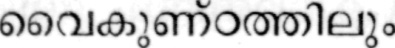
വൈകുണ്ഠത്തിലും
